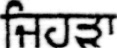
ਜਿਹੜਾ
